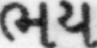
ભય
